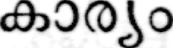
കാര്യം
